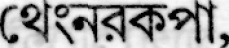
থেংনরকপা,
